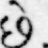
છે.
